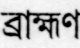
ব্রাহ্মণ
